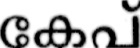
കേപ്
